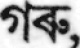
গৰু,
